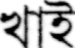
খাই
